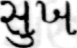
સુખ
